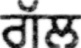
ਗੱਲ
